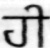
ਹੀ
